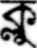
ক্লু
